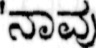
‘ನಾವು
